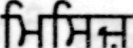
ਮਿਸਿਜ਼
